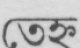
তেহ্ন
